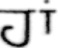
ਹਾਂ
